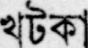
খটকা
